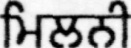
ਮਿਲਨੀ
